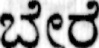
ಬೇರೆ
